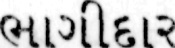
ભાગીદાર
